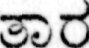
ತಾರ
